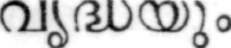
വൃദ്ധയും
